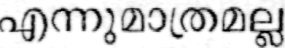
എന്നുമാത്രമല്ല
